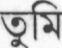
তুমি
